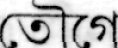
তৌগে
